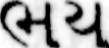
ભય
